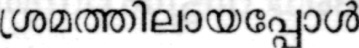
ശ്രമത്തിലായപ്പോള്‍
